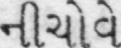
નીચોવે
